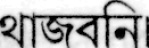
থাজবনি।
